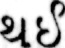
થઈ
